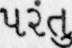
પરંતુ
